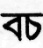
বচ
